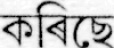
কৰিছে
